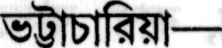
ভট্টাচারিয়া-
